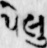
પેલું
